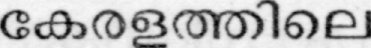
കേരളത്തിലെ
